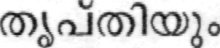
തൃപ്തിയും
